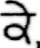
ਕੇ,
